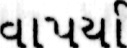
વાપર્યા
